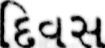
દિવસ
